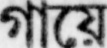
গায়ে
